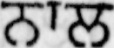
ਨਾਲ
